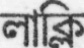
লাক্লি
